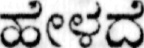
ಹೇಳದೆ
